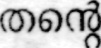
തന്റെ
